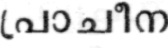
പ്രാചീന
